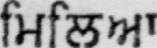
ਮਿਲਿਆ
